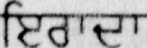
ਇਰਾਦਾ
